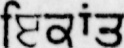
ਇਕਾਂਤ
